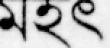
মহৎ
